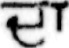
ਦਾ
